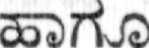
ಹಾಗೂ
